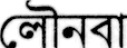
লৌনবা
